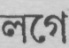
লগে
